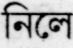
নিলে
